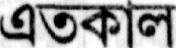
এতকাল
